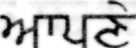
ਆਪਣੇ
